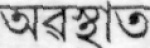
অৱস্হাত
